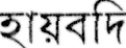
হায়বদি
